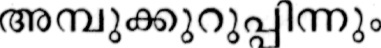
അമ്പുക്കുറുപ്പിന്നും
